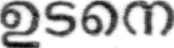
ഉടനെ
